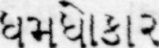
ધમધોકાર
